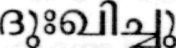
ദുഃഖിച്ചു
